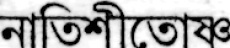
নাতিশীতোষ্ণ
